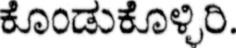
ಕೊಂಡುಕೊಳ್ಳಿರಿ.
